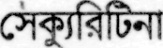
সেক্যুরিটিনা
